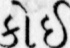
કોઈ
